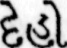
દેહો
